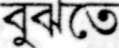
বুঝতে
